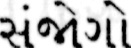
સંજોગો
